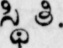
ಸ್ಥಿತಿ.
